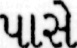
પાસે
